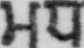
ਮਧ
